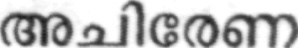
അചിരേണ
